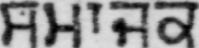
ਸਮਾਜਕ
